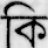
কি
